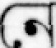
নে
